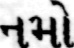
નમો
